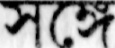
সঙ্গে
